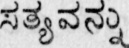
ಸತ್ಯವನ್ನು
